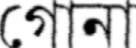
গোনা
